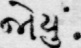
જોયું.
